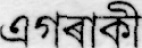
এগৰাকী
